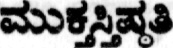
ಮುಕ್ತಸ್ತಿಷ್ಠತಿ
